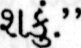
શકું."
